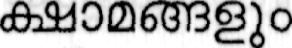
ക്ഷാമങ്ങളും
